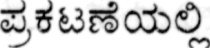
ಪ್ರಕಟಣೆಯಲ್ಲಿ
